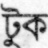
টুক
